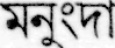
মনুংদা
